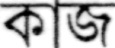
কাজ
